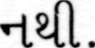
નથી.
